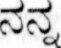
ನನ್ನ
